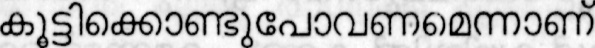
കൂട്ടിക്കൊണ്ടുപോവണമെന്നാണ്
